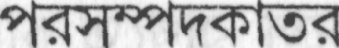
পরসম্পদকাতর
